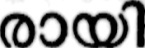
രായി
